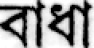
বাধা
